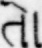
તો
